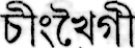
চীংখৈগী
